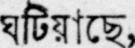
ঘটিয়াছে,
